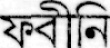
ফবীনি
